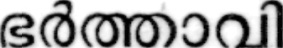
ഭര്‍ത്താവി
